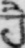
ਹੈ
